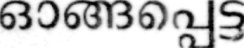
ഓങ്ങപ്പെട്ട
